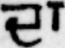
ਦਾ
